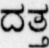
ದತ್ತ
